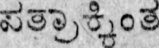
ಪತ್ರಾಕ್ಕಿಂತ
